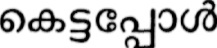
കെട്ടപ്പോള്‍
